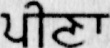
ਪੀਣਾ
